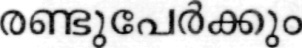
രണ്ടുപേര്‍ക്കും
